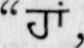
''ਹਾਂ,
